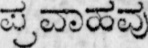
ಪ್ರವಾಹವು
